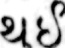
થઈ
